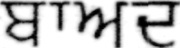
ਬਾਅਦ
